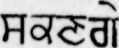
ਸਕਣਗੇ
